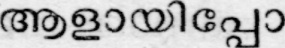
ആളായിപ്പോ
